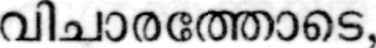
വിചാരത്തോടെ,
